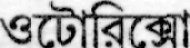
ওটোরিক্সো
